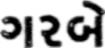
ગરબે
